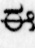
ಈ
